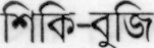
শিকি-বুজি
